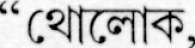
"থোলোক,
